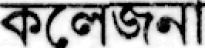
কলেজনা
